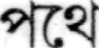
পথে
